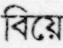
বিয়ে
